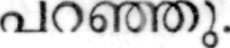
പറഞ്ഞു.
